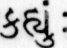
કહ્યું:
